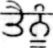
ਤੈਨੂੰ
